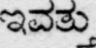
ಇವತ್ತು
